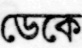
ডেকে
